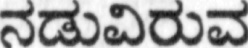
ನಡುವಿರುವ
